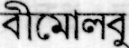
বীমোলবু
